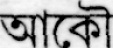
আকৌ
